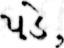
પડે,
